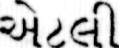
એટલી
